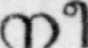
നീ
